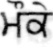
ਮੌਕੇ
